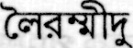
লৈরম্মীদু
